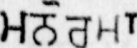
ਮਨੋਰਮਾ
